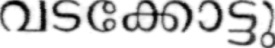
വടക്കോട്ടു
